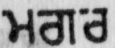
ਮਗਰ
